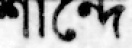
শান্দে
